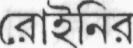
রোইনির
